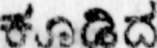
ಕೂಡಿದ
